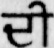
ਦੀ
